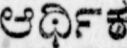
ಆರ್ಥಿಕ
